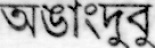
অঙাংদুবু
